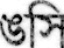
ঙসি
